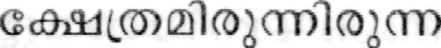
ക്ഷേത്രമിരുന്നിരുന്ന
